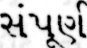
સંપૂર્ણ
